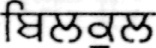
ਬਿਲਕੁਲ
